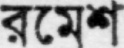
রমেশ
